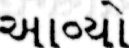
આવ્યો
